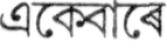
একেবাৰে
